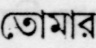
তোমার
